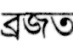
ব্রজত
